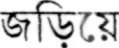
জড়িয়ে
